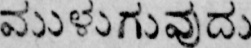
ಮುಳುಗುವುದು
